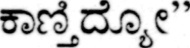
ಕಾಣ್ತಿದ್ಯೋ"
